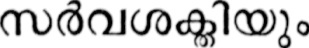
സര്‍വശക്തിയും
